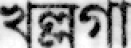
খল্লগা
